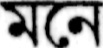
মনে
